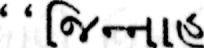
"જિન્નાહ
